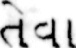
તેવા
